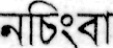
নচিংবা
